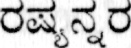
ರಷ್ಯನ್ನರ
